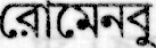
রোমেনবু
